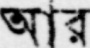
আর
